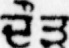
ਦੌੜ
